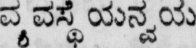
ವ್ಯವಸ್ಥೆಯನ್ವಯ
